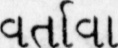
વર્તાવા
